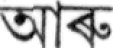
আৰু
